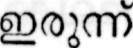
ഇരുന്ന്
